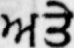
ਅਤੇ
